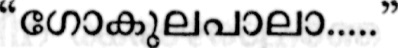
“ഗോകുലപാലാ.....”
